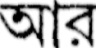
আর
